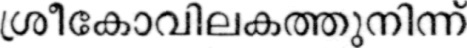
ശ്രീകോവിലകത്തുനിന്ന്
